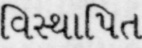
વિસ્થાપિત
